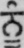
ਨੂੰ
